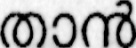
താന്‍
